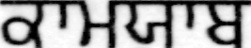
ਕਾਮਯਾਬ
